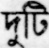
দুটি
